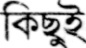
কিছুই
